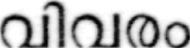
വിവരം
